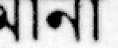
মানা
